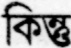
কিন্তু
